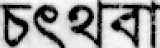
চৎথবা
